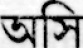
অসি
